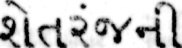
શેતરંજની
